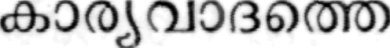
കാര്യവാദത്തെ
